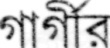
গার্গীর
